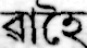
ৱাহৈ
